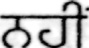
ਨਹੀਂ
